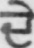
ਦੇ
